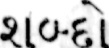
શબ્દો
